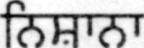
ਨਿਸ਼ਾਨਾ
